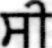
ਸੀ
